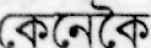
কেনেকৈ
